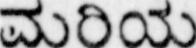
ಮರಿಯ
